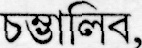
চম্ভালিব,
